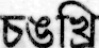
চঙখ্রি
